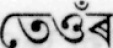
তেওঁৰ
